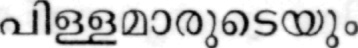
പിള്ളമാരുടെയും
